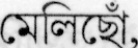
মেলিছোঁ,
